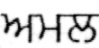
ਅਮਲ
